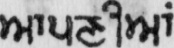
ਆਪਣੀਆਂ
